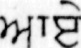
ਆਏ
